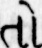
તો
